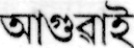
আগুৱাই
